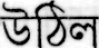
উঠিল
